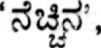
'ನೆಚ್ಚಿನ',
